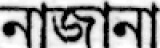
নাজানা
